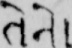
તેનો
